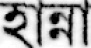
হান্না
